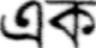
এক
